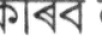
কৰিব
